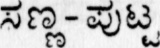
ಸಣ್ಣ-ಪುಟ್ಟ
